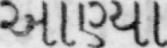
આણ્યા
